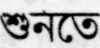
শুনতে
